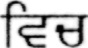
ਵਿਚ
